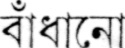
বাঁধানো
